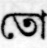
তো
